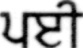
ਪਈ
